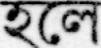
হলে
